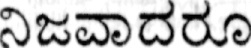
ನಿಜವಾದರೂ
